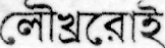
লৌখ্ররোই
